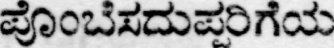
ಪೊಂಬೆಸದುಪ್ಪರಿಗೆಯ
